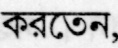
করতেন,
